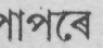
পাপৰে
